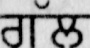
ਗੱਲ
